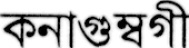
কনাগুম্বগী
